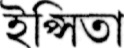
ইপ্সিতা
